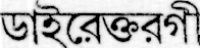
ডাইরেক্তরগী
